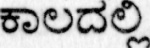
ಕಾಲದಲ್ಲಿ
